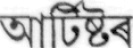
আৰ্টিষ্টৰ
